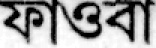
ফাওবা
